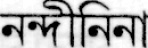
নন্দীনিনা
